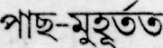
পাছ-মুহূর্তত
